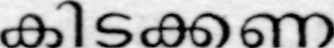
കിടക്കണ
